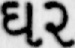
ઘર
